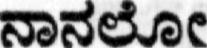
ನಾನಲೋ
